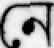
নে
